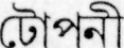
টোপনী
